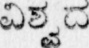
ವಿಶ್ವದ
